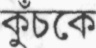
কুঁচকে
